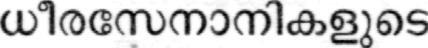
ധീരസേനാനികളുടെ
